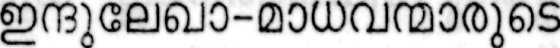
ഇന്ദുലേഖാ-മാധവന്മാരുടെ
